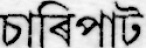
চাৰিপাট
